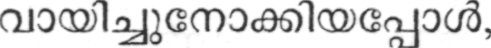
വായിച്ചുനോക്കിയപ്പോള്‍,
